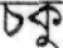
চকু
